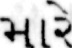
મારે
